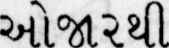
ઓજારથી
